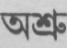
অশ্ৰু
